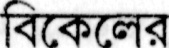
বিকেলের
